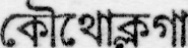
কৌথোক্লগা
